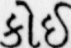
કોઈ
